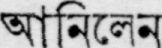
আনিলেন
